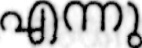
എന്നു
